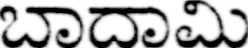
ಬಾದಾಮಿ
